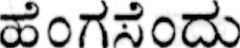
ಹೆಂಗಸೆಂದು
